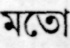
মতো
